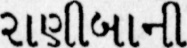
રાણીબાની
